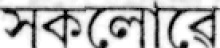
সকলোৱে
